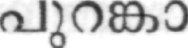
പുറങ്കാ
